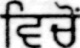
ਵਿਚੋਂ
